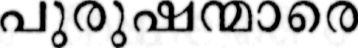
പുരുഷന്മാരെ
